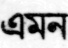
এমন
